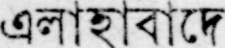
এলাহাবাদে
